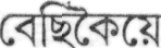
বেছিকৈয়ে
